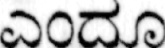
ಎಂದೂ
